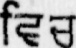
ਵਿਚ
